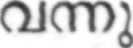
വന്നു
